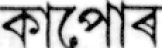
কাপোৰ
